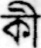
কী
